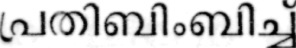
പ്രതിബിംബിച്ച്
